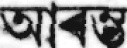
আৰম্ভ
